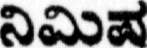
ನಿಮಿಷ
